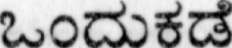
ಒಂದುಕಡೆ
